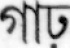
গাঢ়
